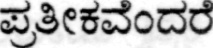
ಪ್ರತೀಕವೆಂದರೆ
